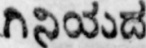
ಗಿನಿಯದ
